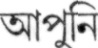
আপুনি
